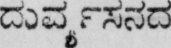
ದುರ್ವ್ಯಸನದ
